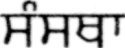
ਸੰਸਥਾ
